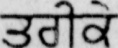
ਤਰੀਕੇ
